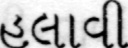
હલાવી
